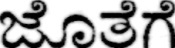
ಜೊತೆಗೆ
